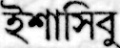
ইশাসিবু
